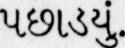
પછાડયું.
